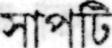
সাপটি
